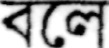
বলে
